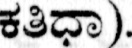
ಕತಿಧಾ).
